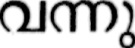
വന്നു
